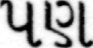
પણ
